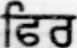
ਫਿਰ
